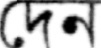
দেন
